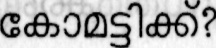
കോമട്ടിക്ക്?
